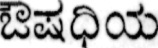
ಔಷಧಿಯ
